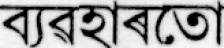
ব্যৱহাৰতো
